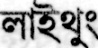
লাইথুং
